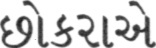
છોકરાએ
